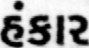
હંકાર
